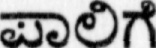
ಪಾಲಿಗೆ
